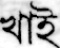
খাই
